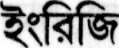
ইংরিজি
